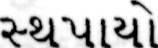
સ્થપાયો
